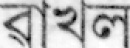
ৱাখল
